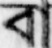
বা
